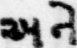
અને
